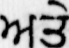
ਅਤੇ
